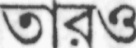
তারও
